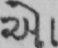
ઓ
